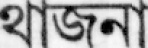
থাজনা
